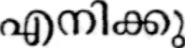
എനിക്കു
